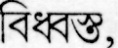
বিধ্বস্ত,
